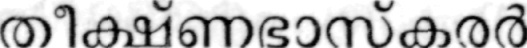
തീക്ഷ്ണഭാസ്കരര്‍
